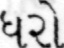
ધરો
